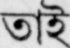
তাই
